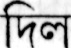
দিল
